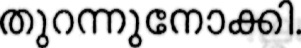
തുറന്നുനോക്കി.
